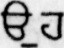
ਉਹ
